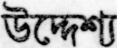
উদ্দেশ্য
